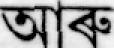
আৰু
